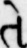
તે
